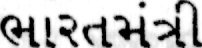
ભારતમંત્રી
